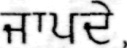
ਜਾਪਦੇ,
